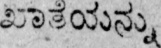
ಖಾತೆಯನ್ನು
